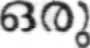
ഒരു
